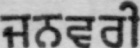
ਜਨਵਰੀ
